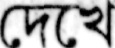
দেখে
